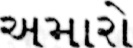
અમારો
